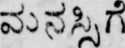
ಮನಸ್ಸಿಗೆ
